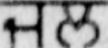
ਜਲ
